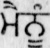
ਮੈਨੂੰ
